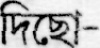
দিছো-
